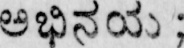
ಅಭಿನಯ;
